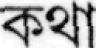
কথা
